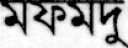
মফমদু
